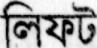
লিফট
